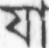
যা
